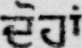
ਦੋਹਾਂ
